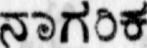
ನಾಗರಿಕ
